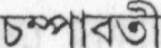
চম্পাবতী
